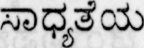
ಸಾಧ್ಯತೆಯ
